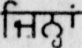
ਜਿਨ੍ਹਾਂ
